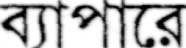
ব্যাপারে
